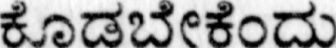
ಕೊಡಬೇಕೆಂದು
